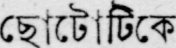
ছোটোটিকে
